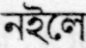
নইলে
